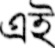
এই
